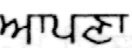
ਆਪਣਾ
